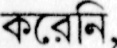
করেনি,
